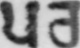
ਪਰ
